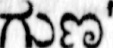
ಗುಣ’
